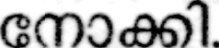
നോക്കി.
